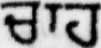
ਚਾਹ
